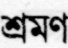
শ্রমণ
